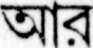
আর
